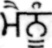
ਮੈਨੂੰ
